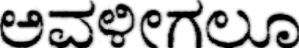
ಅವಳೀಗಲೂ
